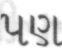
પણ
